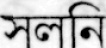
সলনি
